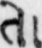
તો
